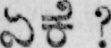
ಏಕೆ?
